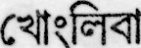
খোংলিবা
